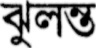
ঝুলন্ত
